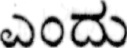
ಎಂದು
